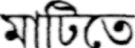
মাটিতে
